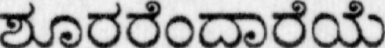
ಶೂರರೆಂದಾರೆಯೆ
